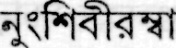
নুংশিবীরম্বা
